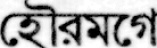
হৌরমগে
